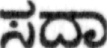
ಸದಾ
